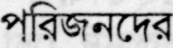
পরিজনদের
